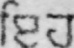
ਇਹ
